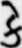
કે
